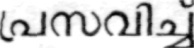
പ്രസവിച്ച്
